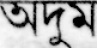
অদুম
